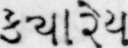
ક્યારેય
